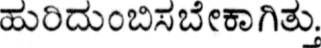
ಹುರಿದುಂಬಿಸಬೇಕಾಗಿತ್ತು.
